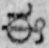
ಈ
